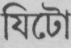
যিটো
